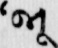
'જુ
